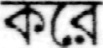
করে
